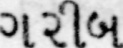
ગરીબ
